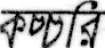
কচ্চরি
